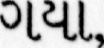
ગયા,
